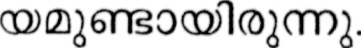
യമുണ്ടായിരുന്നു.
